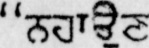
''ਨਹਾਉਣ
